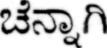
ಚೆನ್ನಾಗಿ
